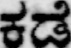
ಕಡೆ
